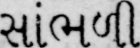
સાંભળી
